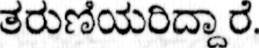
ತರುಣಿಯರಿದ್ದಾರೆ.
